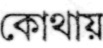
কোথায়
